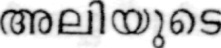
അലിയുടെ
